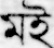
মই
